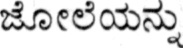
ಜೋಲೆಯನ್ನು
